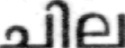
ചില
